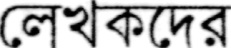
লেখকদের
